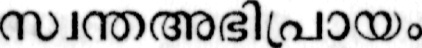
സ്വന്തഅഭിപ്രായം
